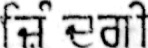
ਜ਼ਿੰਦਗੀ
